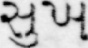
સુખ
